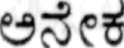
ಅನೇಕ
